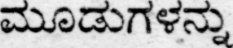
ಮೂಡುಗಳನ್ನು
